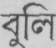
বুলি
